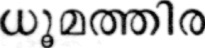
ധൂമത്തിര
